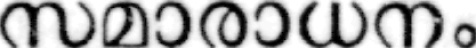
സമാരാധനം
